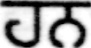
ਹਨ
